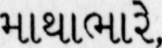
માથાભારે,
